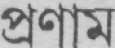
প্ৰণাম
